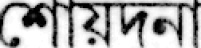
শোয়দনা
